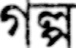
গল্প
